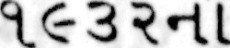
૧૯૩૨ના
